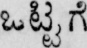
ಒಟ್ಟಿಗೆ
